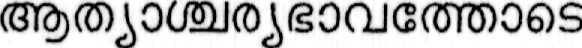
ആത്യാശ്ചര്യഭാവത്തോടെ
